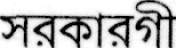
সরকারগী
